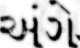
અંગે
